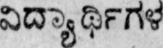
ವಿದ್ಯಾರ್ಥಿಗಳ
